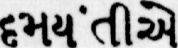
દમયંતીએ
